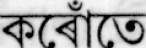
কৰোঁতে
